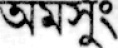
অমসুং
